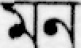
মন
